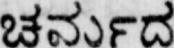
ಚರ್ಮದ
